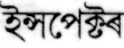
ইন্সপেক্টৰ
